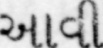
આવી
